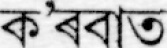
ক'ৰবাত
